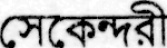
সেকেন্দরী
